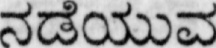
ನಡೆಯುವ
